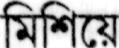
মিশিয়ে
